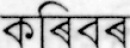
কৰিবৰ
